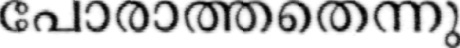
പോരാത്തതെന്നു
